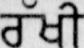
ਰੱਖੀ
